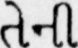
તેની
